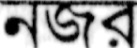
নজর
